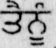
ਤੈਨੂੰ
